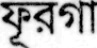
ফূরগা
